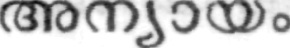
അന്യായം
